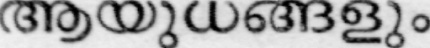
ആയുധങ്ങളും
